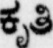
ಕೃತಿ
